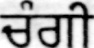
ਚੰਗੀ
